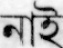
নাই
